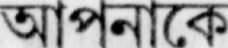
আপনাকে
